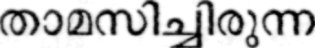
താമസിച്ചിരുന്ന
